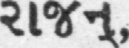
રાજન્,
